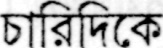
চারিদিকে
